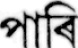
পাৰি
